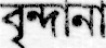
বৃন্দানা
